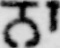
ਨਾ
